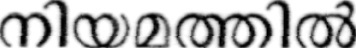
നിയമത്തില്‍
